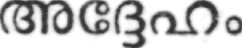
അദ്ദേഹം
